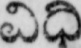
ವಿಧಿ
